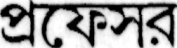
প্রফেসর
